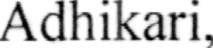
Adhikari,
